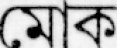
মোক
